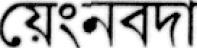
য়েংনবদা
